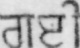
ਗਈ
